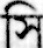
সি
